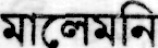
মালেমনি
